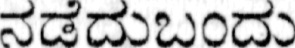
ನಡೆದುಬಂದು
